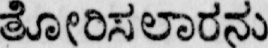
ತೋರಿಸಲಾರನು
